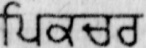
ਪਿਕਚਰ
